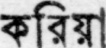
করিয়া
